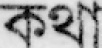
কথা
